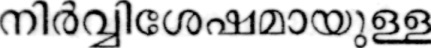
നിര്‍വ്വിശേഷമായുള്ള
